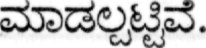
ಮಾಡಲ್ಪಟ್ಟಿವೆ.
